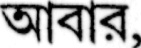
আবার,
